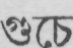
গুচে
